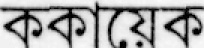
ককায়েক
